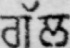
ਗੱਲ
